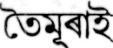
তৈমূৰাই
